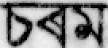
চৰম
